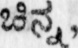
ಚಿನ್ನ,
